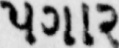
પગાર
